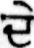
ਦੇ
